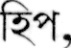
হিপ,
